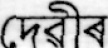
দেৱীৰ
